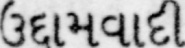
ઉદામવાદી
